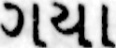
ગયા
